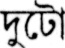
দুটো
